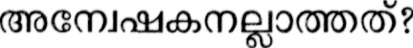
അന്വേഷകനല്ലാത്തത്?
